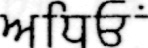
ਅਧਿਓਂ
